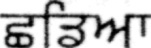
ਛਡਿਆ
